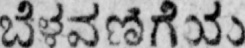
ಬೆಳವಣಿಗೆಯ
